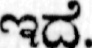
ಇದೆ.
